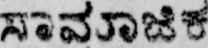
ಸಾಮಾಜಿಕ
